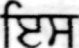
ਇਸ
